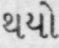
થયો
